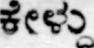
ಕೇಳ್ದು
